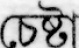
চেষ্টা
